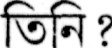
তিনি?
